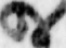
જ
